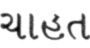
ચાહત
